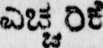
ಎಚ್ಚರಿಕೆ
